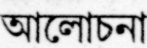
আলোচনা
